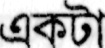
একটা
